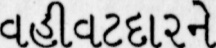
વહીવટદારને
